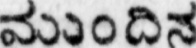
ಮುಂದಿನ
